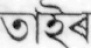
তাইৰ
